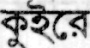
কুইরে
